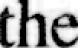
the
